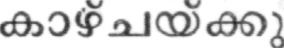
കാഴ്ചയ്ക്കു
